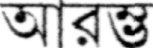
আরম্ভ
